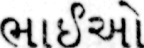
ભાઈઓ
